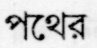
পথের
